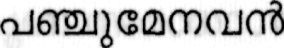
പഞ്ചുമേനവന്‍
